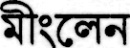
মীংলেন
